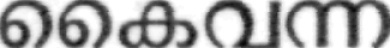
കൈവന്ന
